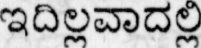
ಇದಿಲ್ಲವಾದಲ್ಲಿ
